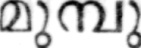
മുമ്പു
